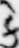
કે
